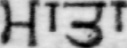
ਮਾਤਾ
